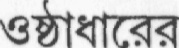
ওষ্ঠাধারের
